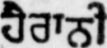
ਹੈਰਾਨੀ
